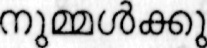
നുമ്മള്‍ക്കു
